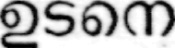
ഉടനെ
